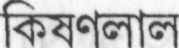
কিষণলাল
